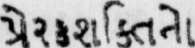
પ્રેરકશક્તિનો
